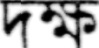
দক্ষ
